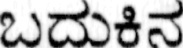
ಬದುಕಿನ
